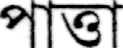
পাত্তা
